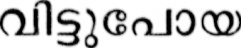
വിട്ടുപോയ
